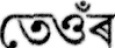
তেওঁৰ
